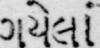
ગયેલાં
